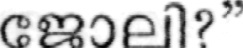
ജോലി?"
